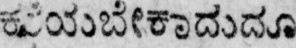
ಕರೆಯಬೇಕಾದುದೂ
